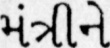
મંત્રીને
